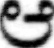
ಆ
